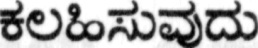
ಕಲಹಿಸುವುದು
